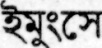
ইমুংসে
